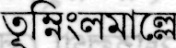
তুম্নিংলমাল্লে
